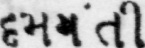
દમયંતી
